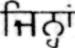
ਜਿਨ੍ਹਾਂ
